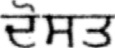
ਦੋਸਤ
